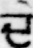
ਦੇ
